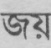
জয়
